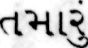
તમારું
